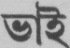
ভাই
